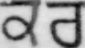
ਕਰ
